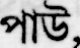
পাউ,
